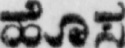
ಹೊಸ
